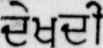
ਦੇਖਦੀ
